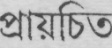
প্রায়চিত
